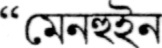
“মেনহুইন
